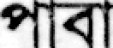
পাবা
